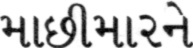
માછીમારને
